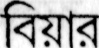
বিয়ার
